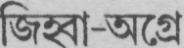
জিহ্বা-অগ্ৰে
